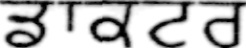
ਡਾਕਟਰ
